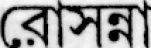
রোসন্না
